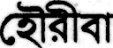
হৌরীবা
